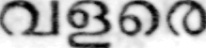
വളരെ
